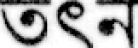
তৎন
